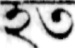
হত
